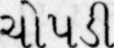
ચોપડી
